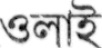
ওলাই
